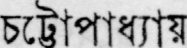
চট্টোপাধ্যায়
